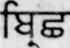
ਬ੍ਰਿਛ
